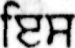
ਇਸ
